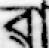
ৱা
